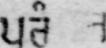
ਪਰੰ
